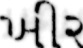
ખીર
